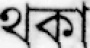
থকা
